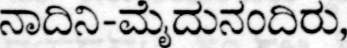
ನಾದಿನಿ-ಮೈದುನಂದಿರು,
